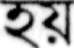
হয়
